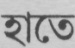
হাতে
